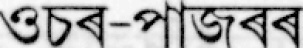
ওচৰ-পাজৰৰ
